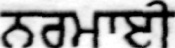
ਨਰਮਾਈ
